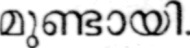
മുണ്ടായി.
